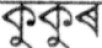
কুকুৰ
